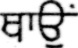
ਥਾਉਂ
